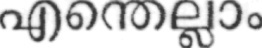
എന്തെല്ലാം
